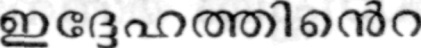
ഇദ്ദേഹത്തിന്റെ
